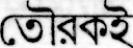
তৌরকই
